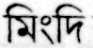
মিংদি
